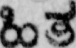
ಹಿತ
